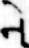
ને
